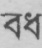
বধ
